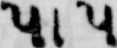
પાપ
